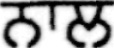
ਨਾਲ
